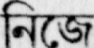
নিজে
